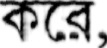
করে,
